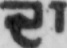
ਦਾ
